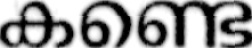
കണ്ടെ
